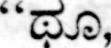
"ಥೂ,
